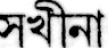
সখীনা
